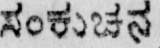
ಸಂಕುಚನ
